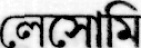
লেসোমি
